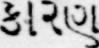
કારણ
